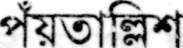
পঁয়তাল্লিশ
